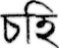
চহি
